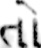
તો
